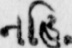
નહિ.
